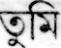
তুমি
